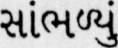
સાંભળ્યું
